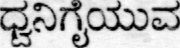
ಧ್ವನಿಗೈಯುವ
